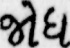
જોધ
